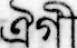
ঐগী
